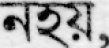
নহয়,
